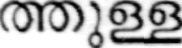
ത്തുള്ള
